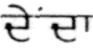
ਦੇਂਦਾ
